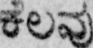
ಕೆಲವು
